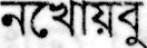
নখোয়বু
